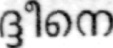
ദ്ദീനെ
